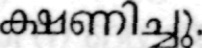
ക്ഷണിച്ചു.
